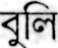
বুলি
